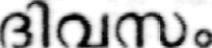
ദിവസം
